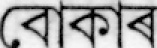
বোকাৰ
